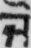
ਜੋ
